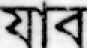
যাব
